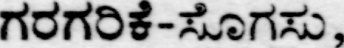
ಗರಗರಿಕೆ-ಸೊಗಸು,
